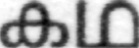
കഥ
